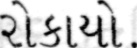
રોકાયો.
